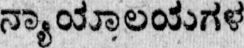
ನ್ಯಾಯಾಲಯಗಳ
